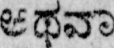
ಅಥವಾ
